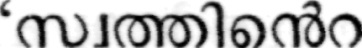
'സ്വത്തിന്റെ
